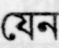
যেন
